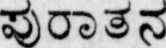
ಪುರಾತನ
